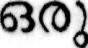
ഒരു
